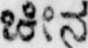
ಚೀನ
